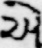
એ
